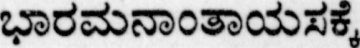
ಭಾರಮನಾಂತಾಯಸಕ್ಕೆ
